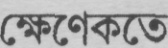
ক্ষেণেকতে
